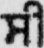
ਸੀ
